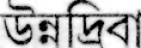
উন্নদ্রিবা
